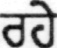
ਰਹੇ
